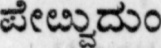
ಪೇೞ್ವುದುಂ
